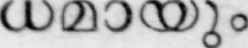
ധമായും
